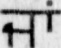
ਜਾਂ
